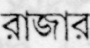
রাজার
